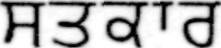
ਸਤਕਾਰ
